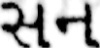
સન
